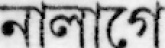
নালাগে
